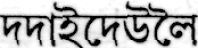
দদাইদেউলৈ
